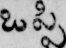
ಒಪ್ಪಿ
